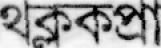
থক্লকপ্রা
